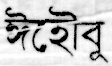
ঈহৌবু
